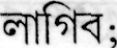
লাগিব;
